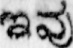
ಇವು
